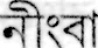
নীংবা
